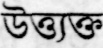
উত্ত্যক্ত
